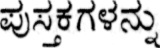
ಪುಸ್ತಕಗಳನ್ನು
